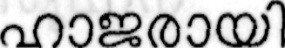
ഹാജരായി
